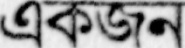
একজন
